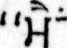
''ਮੈਂ
